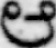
ಆ
